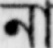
না
